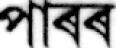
পাৰৰ
